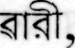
ৱারী,
